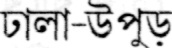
ঢালা-উপুড়
